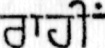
ਰਾਹੀਂ
